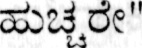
ಹುಚ್ಚರೇ”
